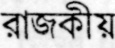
রাজকীয়
